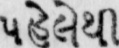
પહેલેથી
